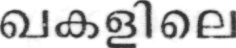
ഖകളിലെ
